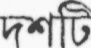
দশটি
